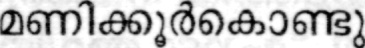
മണിക്കൂര്‍കൊണ്ടു
